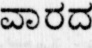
ವಾರದ
